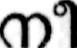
നീ
